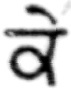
ਕੇ
